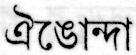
ঐঙোন্দা
